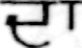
ਦਾ
